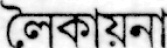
লৈকায়না
